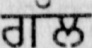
ਗੱਲ
